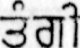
ਤੰਗੀ
